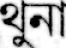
থুনা
